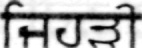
ਜਿਹੜੀ
